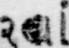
રહ્યાં
